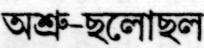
অশ্রু-ছলোছল
